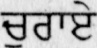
ਚੁਰਾਏ
